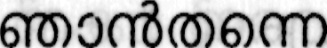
ഞാന്‍തന്നെ
